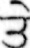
ਤੇ
